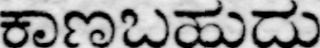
ಕಾಣಬಹುದು
